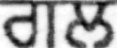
ਗਲ
